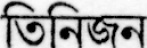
তিনিজন
